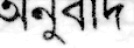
অনুবাদ
